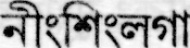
নীংশিংলগা
